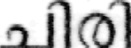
ചിരി
